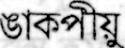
ঙাকপীয়ু
